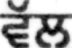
ਵੱਲ
